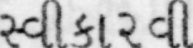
સ્વીકારવી
